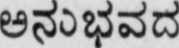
ಅನುಭವದ
